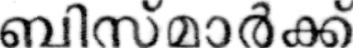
ബിസ്മാര്‍ക്ക്
